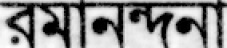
রমানন্দনা
